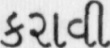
કરાવી
